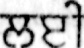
ਲਈ
